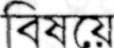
বিষয়ে
